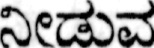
ನೀಡುವ
